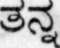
ತನ್ನ
